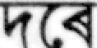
দৰে
